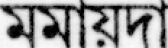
মমায়দা
